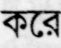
করে
